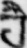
ਹੈ
